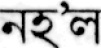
নহ'ল
